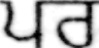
ਪਰ
